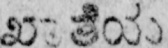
ಖಾತೆಯ
